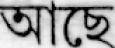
আছে
